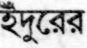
ইঁদুরের
